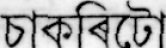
চাকৰিটো
